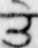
ਤੇ
